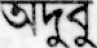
অদুবু
